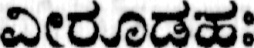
ವೀರೂಡಹಃ
